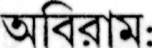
অবিরাম;
